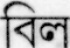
বিল
